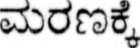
ಮರಣಕ್ಕೆ
